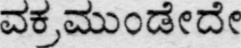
ವಕ್ರಮುಂಡೇದೇ
